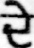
ਦੇ
